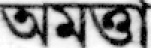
অমত্তা
